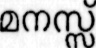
മനസ്സ്
